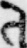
તે
